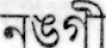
নঙগী
